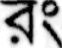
রং
